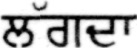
ਲੱਗਦਾ
